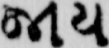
જાય
